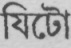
যিটো
